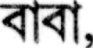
বাবা,
